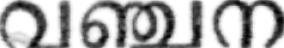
വഞ്ചന
